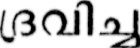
ദ്രവിച്ച
